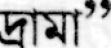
দ্রামা”
